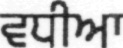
ਵਧੀਆ
